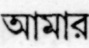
আমার
